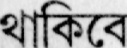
থাকিবে
